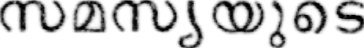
സമസ്യയുടെ
